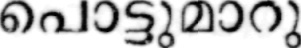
പൊട്ടുമാറു
